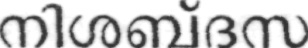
നിശബ്ദസ
